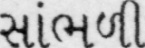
સાંભળી
